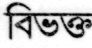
বিভক্ত
